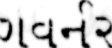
ગવર્નર
